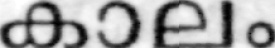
കാലം
